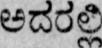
ಅದರಲ್ಲಿ
